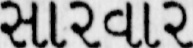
સારવાર
